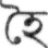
হৈ
